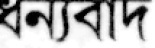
ধন্যবাদ
